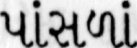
પાંસળાં
